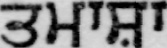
ਤਮਾਸ਼ਾ
